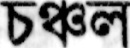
চঞ্চল
